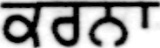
ਕਰਨਾ
